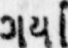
ગયાં
